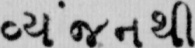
વ્યંજનથી
